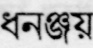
ধনঞ্জয়
